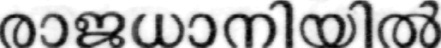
രാജധാനിയില്‍
